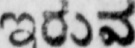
ಇರುವ
